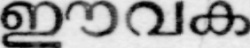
ഈവക
